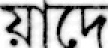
য়াদে
